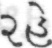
રહે
